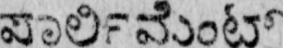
ಪಾರ್ಲಿಮೆಂಟ್
